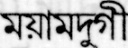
ময়ামদুগী
